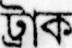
ট্রাক
